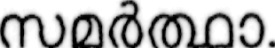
സമര്‍ത്ഥാ.
